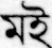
মই
